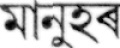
মানুহৰ
